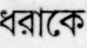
ধরাকে
